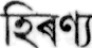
হিৰণ্য
